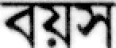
বয়স
